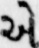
એ
